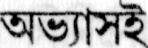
অভ্যাসই
